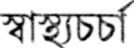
স্বাস্থ্যচর্চা
